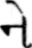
ને
